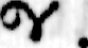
જ.
